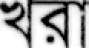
খরা
